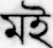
মই
